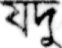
যদু
